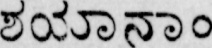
ಶಯಾನಾಂ
